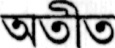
অতীত
